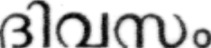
ദിവസം
